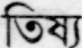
তিষ্য
